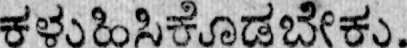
ಕಳುಹಿಸಿಕೊಡಬೇಕು.
